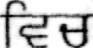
ਵਿਚ
